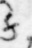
કે,
